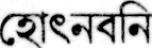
হোৎনবনি
